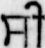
ਸੀ
